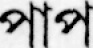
পাপ
